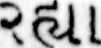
રહ્યા
